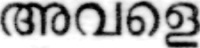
അവളെ
